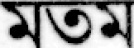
মতম
